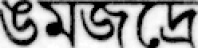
ঙমজদ্রে
